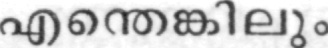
എന്തെങ്കിലും
